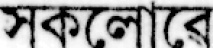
সকলোৱে
